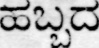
ಹಬ್ಬದ
